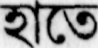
হাতে
